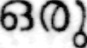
ഒരു
